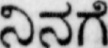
ನಿನಗೆ
